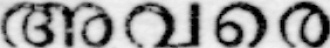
അവരെ
